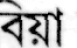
বিয়া
